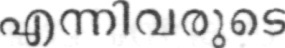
എന്നിവരുടെ
